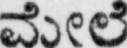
ಮೇಲೆ
